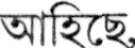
আহিছে,
